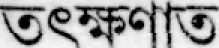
তৎক্ষণাত
